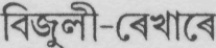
বিজুলী-ৰেখাৰে
